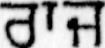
ਰਾਜ
